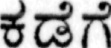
ಕಡೆಗೆ
